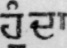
ਹੁੰਦਾ
